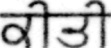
ਕੀਤੀ
